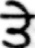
ਤੇ
